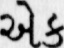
એક
